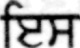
ਇਸ
